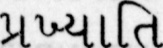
પ્રખ્યાતિ
